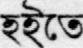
হইতে
